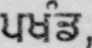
ਪਖੰਡ,
